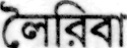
লৈরিবা
